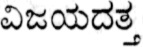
ವಿಜಯದತ್ತ
